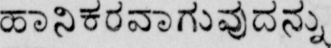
ಹಾನಿಕರವಾಗುವುದನ್ನು
